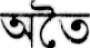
অতৈ
